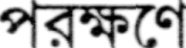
পরক্ষণে
